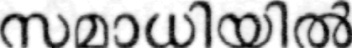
സമാധിയില്‍
